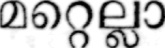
മറ്റെല്ലാ
